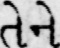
તેને
